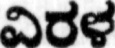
ವಿರಳ
